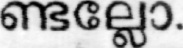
ണ്ടല്ലോ.
